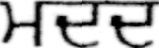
ਮਦਦ
